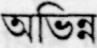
অভিন্ন
